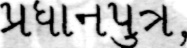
પ્રધાનપુત્ર,
